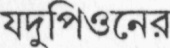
যদুপিওনের
